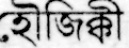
হৌজিক্কী
